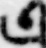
এ
